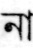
না
